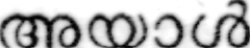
അയാള്‍
